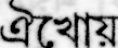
ঐখোয়
